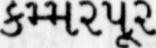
ક્મ્મરપૂર
